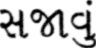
સજાવું
